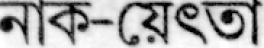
নাক-য়েৎতা
